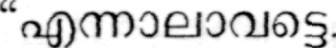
“എന്നാലാവട്ടെ.
